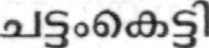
ചട്ടംകെട്ടി
